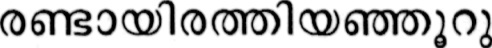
രണ്ടായിരത്തിയഞ്ഞൂറു
